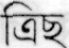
ত্রিছ
